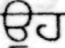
ਉਹ
